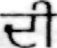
ਦੀ
